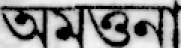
অমত্তনা
